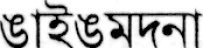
ঙাইঙমদনা
